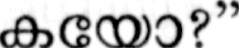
കയോ?”
